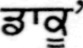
ਡਾਕੂ'
